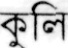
কুলি
